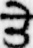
ਤੇ
